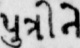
પુત્રીને
